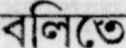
বলিতে
